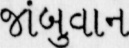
જાંબુવાન
